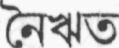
নৈঋত
